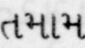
તમામ
